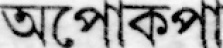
অপোকপা
